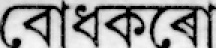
বোধকৰো
